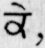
ਕੇ,
